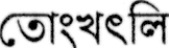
তোংখৎলি
